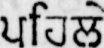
ਪਹਿਲੇ
